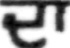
ਦਾ
